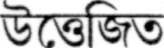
উত্তেজিত
